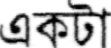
একটা
